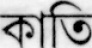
কাতি
